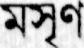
মসৃণ
